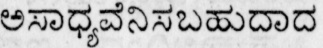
ಅಸಾಧ್ಯವೆನಿಸಬಹುದಾದ
